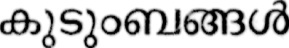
കുടുംബങ്ങള്‍
